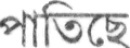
পাতিছে
